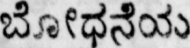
ಬೋಧನೆಯ
